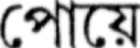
পোয়ে
